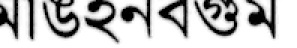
মাঙহনবগুম
